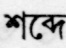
শব্দে
